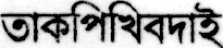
তাকপিখিবদাই
